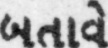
બતાવે
